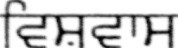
ਵਿਸ਼ਵਾਸ
